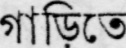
গাড়িতে
